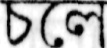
চলে
